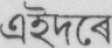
এইদৰে
